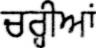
ਚਰ੍ਹੀਆਂ
